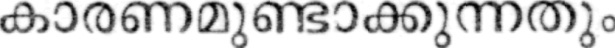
കാരണമുണ്ടാക്കുന്നതും
